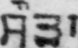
ਸੌੜਾ
